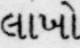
લાખો
